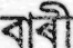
বাৰী
